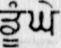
ਡੂੰਘੇ
